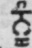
ਨੂੰ
